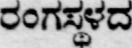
ರಂಗಸ್ಥಳದ
